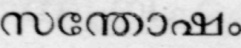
സന്തോഷം
